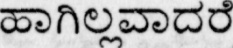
ಹಾಗಿಲ್ಲವಾದರೆ
